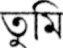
তুমি
